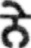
ਨੇ
